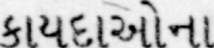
કાયદાઓના
